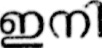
ഇനി
